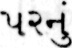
પરનું
